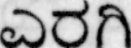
ಎರಗಿ
